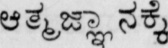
ಆತ್ಮಜ್ಞಾನಕ್ಕೆ
